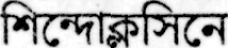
শিন্দোক্লসিনে
